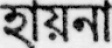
হায়না
